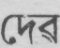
দেৱ
